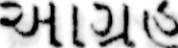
આગ્રહ
